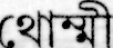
থোম্মী
